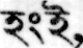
হংই,
